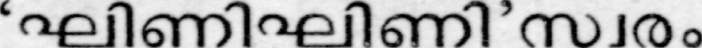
'ഘിണിഘിണി'സ്വരം
